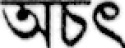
অচৎ
